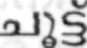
ചൂട്ട്
